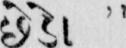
છેડો”
